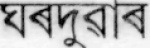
ঘৰদুৱাৰ
